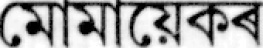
মোমায়েকৰ
